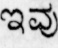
ಇವು
